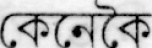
কেনেকৈ
